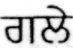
ਗਲੇ
